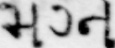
મગ્ન
